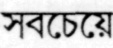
সবচেয়ে
